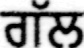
ਗੱਲ
